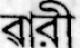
ৱারী
